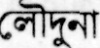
লৌদুনা
